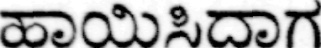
ಹಾಯಿಸಿದಾಗ
